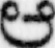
ಆ
